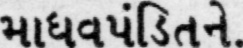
માધવપંડિતને.
